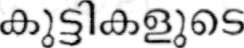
കുട്ടികളുടെ
